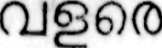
വളരെ
